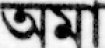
অমা
